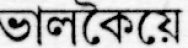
ভালকৈয়ে
